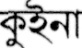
কুইনা
